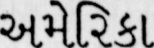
અમેરીકા
